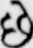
છે
